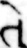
તે
